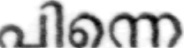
പിന്നെ
